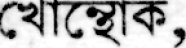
খোন্থোক,
